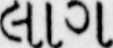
લાગ
